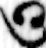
ও
